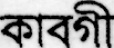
কাবগী
